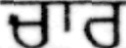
ਚਾਰ
